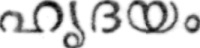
ഹൃദയം
